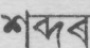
শব্দৰ
